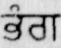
ਭੰਗ
